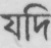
যদি
